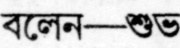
বলেন–শুভ
